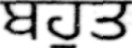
ਬਹੁਤ
